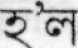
হ'ল
